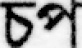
চপ
